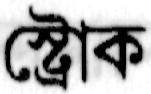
স্ট্রোক
